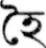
হৈ
